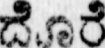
ದೊರೆ
